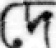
দে
